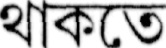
থাকতে
